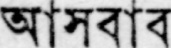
আসবাব
